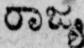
ರಾಜ್ಯ
